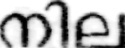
നില
